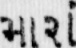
મારાં
